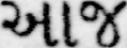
આજ
